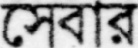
সেবার
